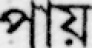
পায়
